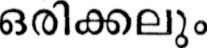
ഒരിക്കലും
